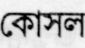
কোসল
